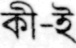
কী-ই
